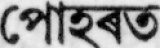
পোহৰত
